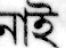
নাই
